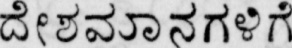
ದೇಶಮಾನಗಳಿಗೆ
